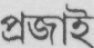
প্ৰজাই
